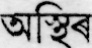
অস্থিৰ
